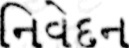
નિવેદન
